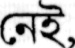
নেই,
